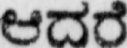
ಆದರೆ
